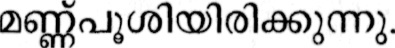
മണ്ണ്പൂശിയിരിക്കുന്നു.
